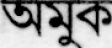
অমুক
